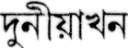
দুনীয়াখন
